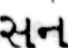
સન
